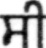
ਸੀ
